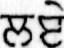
ਲਏ
